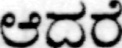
ಆದರೆ
